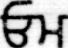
ਓਮ
